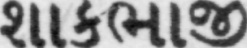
શાકભાજી
